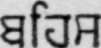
ਬਹਿਸ
